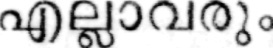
എല്ലാവരും
